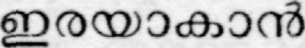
ഇരയാകാന്‍
